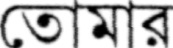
তোমার
